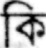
কি
